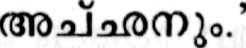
അച്ഛനും.’
